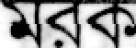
মরক
